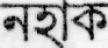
নহাক
